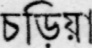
চড়িয়া
